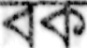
বক
